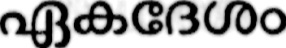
ഏകദേശം
